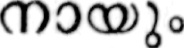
നായും
